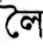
লৈ
